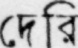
দেরি
